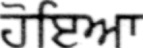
ਹੋਇਆ
